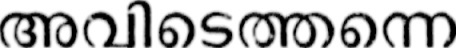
അവിടെത്തന്നെ
